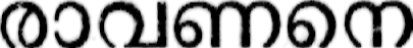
രാവണനെ
